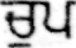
ਚੁਪ
